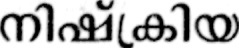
നിഷ്ക്രിയ
